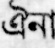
ঐনা
